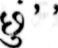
છું"
